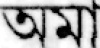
অমা
